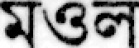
মওল
